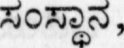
ಸಂಸ್ಥಾನ,
